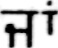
ਜਾਂ
